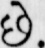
છે.
